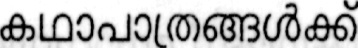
കഥാപാത്രങ്ങള്‍ക്ക്
